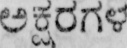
ಅಕ್ಷರಗಳ
